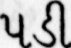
પડી
